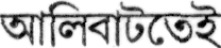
আলিবাটতেই
